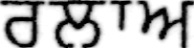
ਰਲਾਅ
